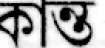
কান্ত
